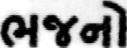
ભજનો
